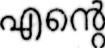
എന്റെ
